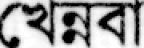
খেন্নবা
